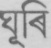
ঘূৰি
